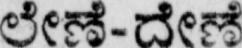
ಲೇಣೆ-ದೇಣೆ
